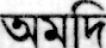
অমদি
